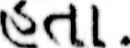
હતા.
